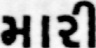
મારી
